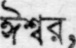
ঈশ্বর,
